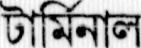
টার্মিনাল
